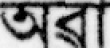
অৱা
